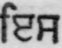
ਇਸ
